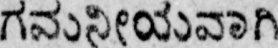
ಗಮನೀಯವಾಗಿ
